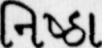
નિષ્ઠા
